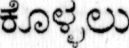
ಕೊಳ್ಳಲು
